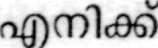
എനിക്ക്
